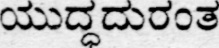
ಯುದ್ಧದುರಂತ
